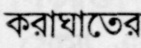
করাঘাতের
